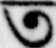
ত
